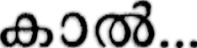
കാല്‍...
